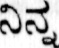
ನಿನ್ನ
